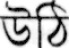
উঠি
